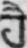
ਹੈ
